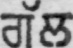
ਗੱਲ
